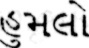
હુમલો
